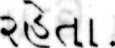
રહેતા.
